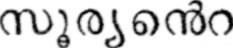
സൂര്യന്റെ
